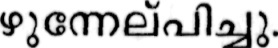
ഴുന്നേല്പിച്ചു.
